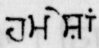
ਹਮੇਸ਼ਾਂ
